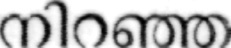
നിറഞ്ഞ
